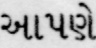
આપણે
